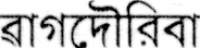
ৱাগদৌরিবা
